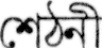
শেঠনী
